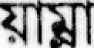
য়াম্না
